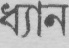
ধ্যান
